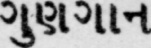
ગુણગાન
